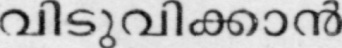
വിടുവിക്കാന്‍
